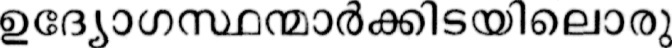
ഉദ്യോഗസ്ഥന്മാര്‍ക്കിടയിലൊരു
